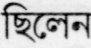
ছিলেন
